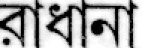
রাধানা
